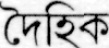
দৈহিক
